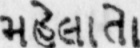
મહેલાતો
